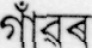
গাঁৱৰ
